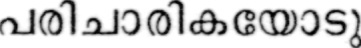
പരിചാരികയോടു
